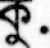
কু.
